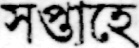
সপ্তাহে
